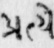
પ્રત્યે
